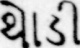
થોડી
